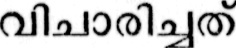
വിചാരിച്ചത്
